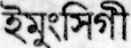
ইমুংসিগী
